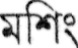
মশিং
